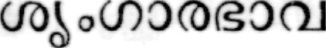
ശൃംഗാരഭാവ
